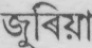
জুৰিয়া
